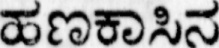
ಹಣಕಾಸಿನ
